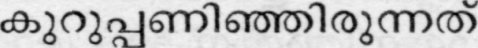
കുറുപ്പണിഞ്ഞിരുന്നത്
